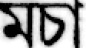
মচা
